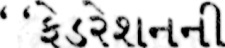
"ફેડરેશનની
